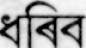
ধৰিব
